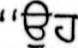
''ਉਹ
